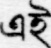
এই
